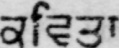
ਕਵਿਤਾ
